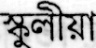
স্কুলীয়া
